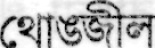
থোঙজীল
